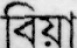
বিয়া
